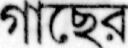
গাছের
